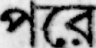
পরে
